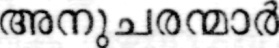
അനുചരന്മാര്‍
